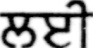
ਲਈ
